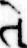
તે
